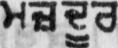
ਮਜ਼ਦੂਰ
